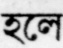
হলে
